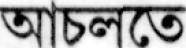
আচলতে
